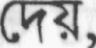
দেয়,
